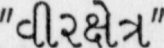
"વીરક્ષેત્ર"
